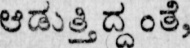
ಆಡುತ್ತಿದ್ದಂತೆ,
